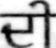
ਦੀ
